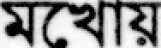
মখোয়
